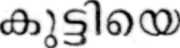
കുട്ടിയെ
